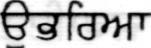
ਉਭਰਿਆ
